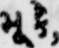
મૂકે,
